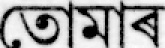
তোমাৰ
